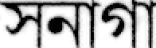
সনাগা
